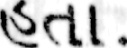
હતા.
